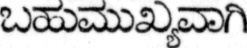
ಬಹುಮುಖ್ಯವಾಗಿ
